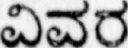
ವಿವರ
